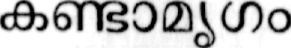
കണ്ടാമൃഗം
